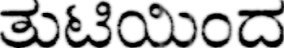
ತುಟಿಯಿಂದ
